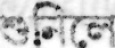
শুনিলে
